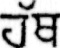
ਹੱਥ
